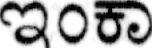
ಇಂಕಾ
